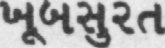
ખૂબસુરત
